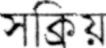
সক্রিয়
